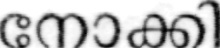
നോക്കി
